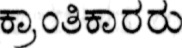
ಕ್ರಾಂತಿಕಾರರು
